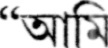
“আমি
